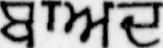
ਬਾਅਦ
